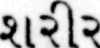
શરીર
